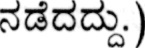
ನಡೆದದ್ದು.)
